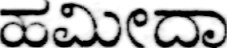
ಹಮೀದಾ
